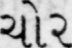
ચોર
